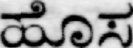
ಹೊಸ
